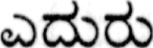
ಎದುರು
